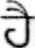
ਹੈ
